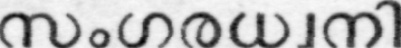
സംഗരധ്വനി
